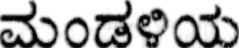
ಮಂಡಳಿಯ
